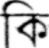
কি
